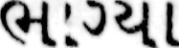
ભાગ્યા
